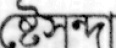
ষ্টেসন্দা
